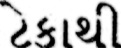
ટેકાથી
